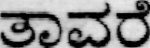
ತಾವರೆ
